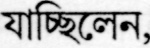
যাচ্ছিলেন,
